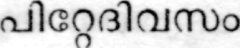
പിറ്റേദിവസം
